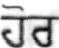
ਹੋਰ
